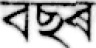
বছৰ
